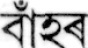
বাঁহৰ
